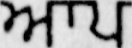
ਆਪ
